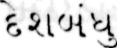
દેશબંધુ
